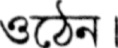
ওঠেন।
